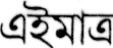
এইমাত্র
